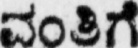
ವಂತಿಗೆ
